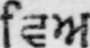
ਵਿਅ
